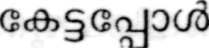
കേട്ടപ്പോള്‍
